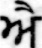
ਐ
